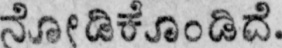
ನೋಡಿಕೊಂಡಿದೆ.
